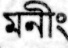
মনীং
